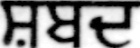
ਸ਼ਬਦ
